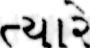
ત્યારે
